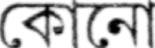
কোনো
